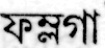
ফম্লগা
